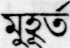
মুহূর্ত
